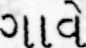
ગાવે
